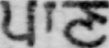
ਪਾਣ
